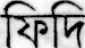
ফিদি
